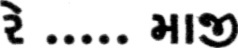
રે........માજી
